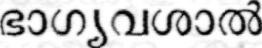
ഭാഗ്യവശാല്‍
